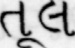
તૂલ
